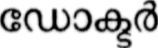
ഡോക്ടര്‍
